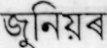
জুনিয়ৰ
